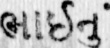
ભાઈનું
